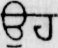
ਉਹ
